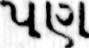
પણ
